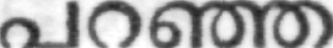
പറഞ്ഞ
